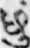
છું
